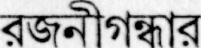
রজনীগন্ধার
